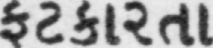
ફટકારતા
